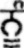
ਨੂੰ
